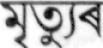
মৃত্যুৰ
